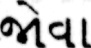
જોવા
